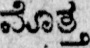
ಮೊತ್ತ
